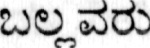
ಬಲ್ಲವರು
